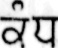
ਕੰਧ
